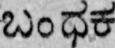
ಬಂಧಕ
